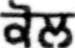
ਕੋਲ
